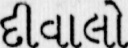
દીવાલો
